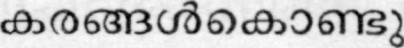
കരങ്ങള്‍കൊണ്ടു
